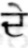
ਦੇ
